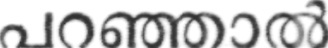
പറഞ്ഞാല്‍
